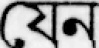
যেন
